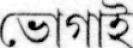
ভোগাই
